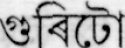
গুৰিটো
